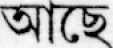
আছে
